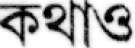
কথাও
